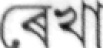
ৰেখা
